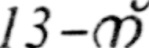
13-ന്
